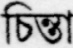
চিন্তা
